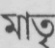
মাতৃ
